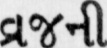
વ્રજની
